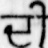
ਦੀ
